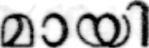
മായി
